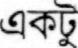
একটু
